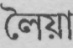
লৈয়া
